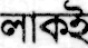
লাকই
